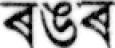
ৰঙৰ
